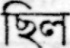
ছিল
